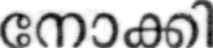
നോക്കി
